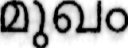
മുഖം
